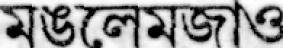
মঙলেমজাও
